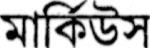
মার্কিউস
